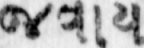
જવાય
